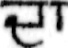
ਦਾ
